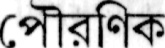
পৌরণিক
